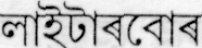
লাইটাৰবোৰ
